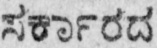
ಸರ್ಕಾರದ
